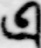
এ
